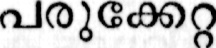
പരുക്കേറ്റ
